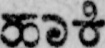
ಹಾಕಿ
